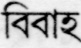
বিবাহ
